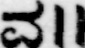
ವ||
